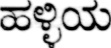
ಹಳ್ಳಿಯ
